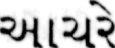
આચરે
